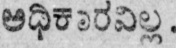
ಅಧಿಕಾರವಿಲ್ಲ.
